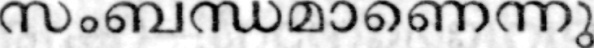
സംബന്ധമാണെന്നു
